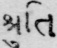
શ્રુતિ
